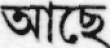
আছে
